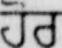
ਹੋਰ
